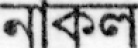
নাকল
